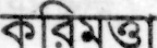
করিমত্তা
